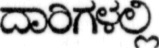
ದಾರಿಗಳಲ್ಲಿ
